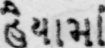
હૈયામાં
